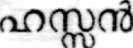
ഹസ്സന്‍
